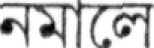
নমালে
